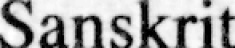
Sanskrit
